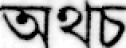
অথচ
